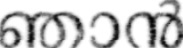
ഞാന്‍
